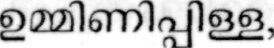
ഉമ്മിണിപ്പിള്ള,
